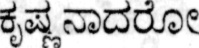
ಕೃಷ್ಣನಾದರೋ
